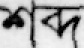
শব্দ
